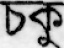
চকু
